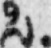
ಸಿ.
